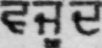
ਵਜੂਦ
